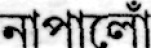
নাপালোঁ
